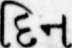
દિન
